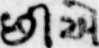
છીએ
